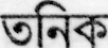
তনিক
